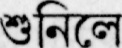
শুনিলে
